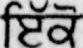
ਇੱਕੋ
